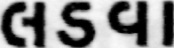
લડવા
